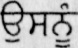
ਉਸਨੂੰ
